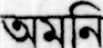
অমনি
